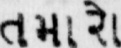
તમારો
